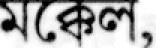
মক্কেল,
